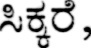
ಸಿಕ್ಕರೆ,
